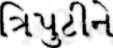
ત્રિપુટીને
